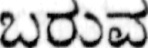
ಬರುವ
